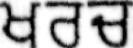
ਖਰਚ
